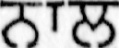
ਨਾਲ
